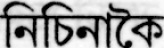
নিচিনাকৈ
